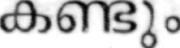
കണ്ടും
